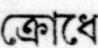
ক্রোধে
